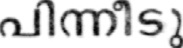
പിന്നീടു
